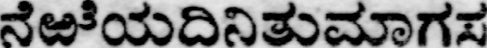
ನೆಱೆಯದಿನಿತುಮಾಗಸ
